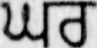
ਘਰ
